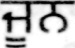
ਜੂਨ
